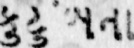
કુટુંબના
